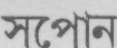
সপোন
